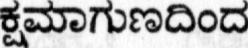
ಕ್ಷಮಾಗುಣದಿಂದ
